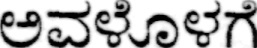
ಅವಳೊಳಗೆ
